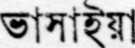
ভাসাইয়া
